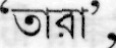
‘তারা’,
